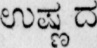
ಉಷ್ಣದ
